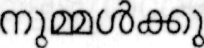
നുമ്മള്‍ക്കു
